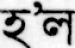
হ'ল
